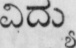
ವಿದ್ಯು
